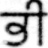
ਭੀ
